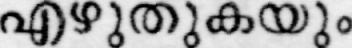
എഴുതുകയും
